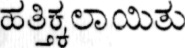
ಹತ್ತಿಕ್ಕಲಾಯಿತು
